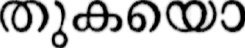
തുകയൊ
